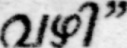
വഴി”
